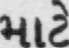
માટે
